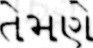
તેમણે
